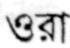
ওরা
